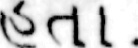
હતા.
